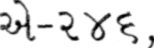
એ-૨૪૬,
